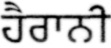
ਹੈਰਾਨੀ
